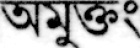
অমুক্তং
